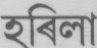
হৰিলা
